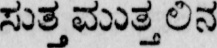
ಸುತ್ತಮುತ್ತಲಿನ
